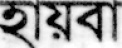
হায়বা
